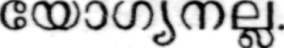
യോഗ്യനല്ല.
